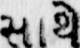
સાથે
